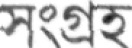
সংগ্রহ
